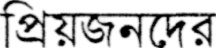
প্রিয়জনদের
